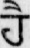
ਹੈ
